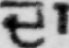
ਦਾ
